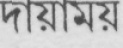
দায়াময়
